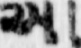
આ
